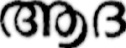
ആദ
